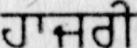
ਹਾਜਰੀ
